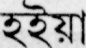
হইয়া
